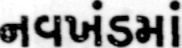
નવખંડમાં
